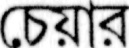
চেয়ার
